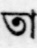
তা
